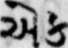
એક
